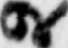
જ
